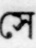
সে
